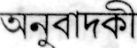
অনুবাদকী
